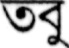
তবু
